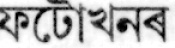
ফটোখনৰ
